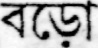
বড়ো
